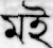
মই
